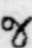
જ
